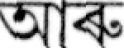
আৰু
